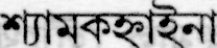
শ্যামকহ্ণাইনা
